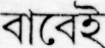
বাবেই
